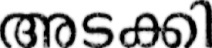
അടക്കി
